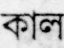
কাল
